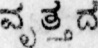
ವೃತ್ತದ
